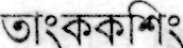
তাংককশিং
